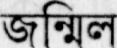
জন্মিল
